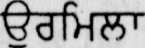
ਉਰਮਿਲਾ
